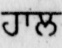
ਹਾਲ
